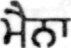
ਮੈਨਾ
